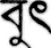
বুৎ
